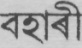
বহাৰী
